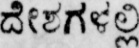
ದೇಶಗಳಲ್ಲಿ
